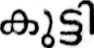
കുട്ടി
